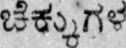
ಚೆಕ್ಕುಗಳ
